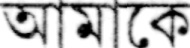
আমাকে
